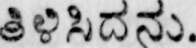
ತಿಳಿಸಿದನು.
